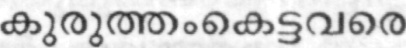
കുരുത്തംകെട്ടവരെ
